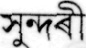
সুন্দৰী
